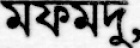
মফমদু,
